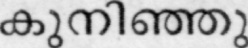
കുനിഞ്ഞു
